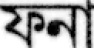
ফনা
